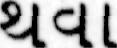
થવા
